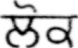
ਲੋਕ
